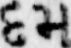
દમ
